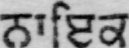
ਨਾਇਕ
